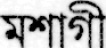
মশাগী
